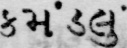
કમંડલું
